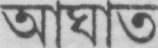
আঘাত
